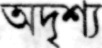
অদৃশ্য
